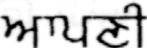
ਆਪਣੀ
